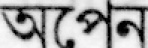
অপেন
